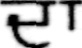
ਦਾ
